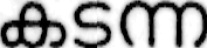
കടന്ന
